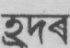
হ্ৰদৰ
